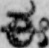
ಈ
